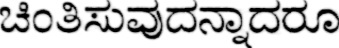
ಚಿಂತಿಸುವುದನ್ನಾದರೂ
